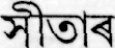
সীতাৰ
